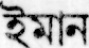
ইমান
